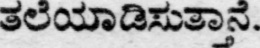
ತಲೆಯಾಡಿಸುತ್ತಾನೆ.
